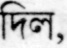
দিল,
